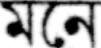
মনে
